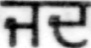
ਜਦ
